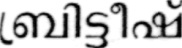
ബ്രിട്ടീഷ്
